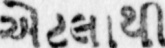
એટલાથી
